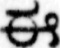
ಈ
